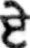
ਏ
